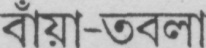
বাঁয়া-তবলা
